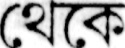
থেকে
